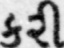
કરી
